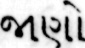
જાણો
